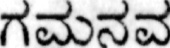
ಗಮನವ
